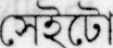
সেইটো
